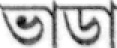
ভাডা
